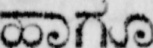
ಹಾಗೂ
